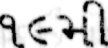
૧૯મી
